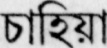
চাহিয়া
